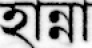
হান্না
